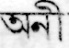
অনী
